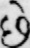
છે
